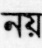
নয়
